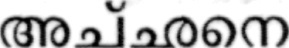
അച്ഛനെ
